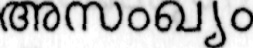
അസംഖ്യം
